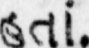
હતાં.
